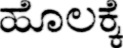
ಹೊಲಕ್ಕೆ
